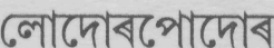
লোদোৰপোদোৰ
